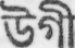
উগী
